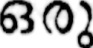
ഒരു
